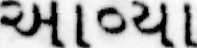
આવ્યા
